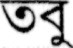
তবু
